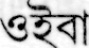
ওইবা
